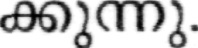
ക്കുന്നു.
